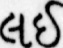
લઈ
